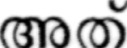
അത്
